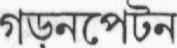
গড়নপেটন
